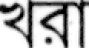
খরা
